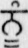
ਨੂੰ
